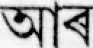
আৰ
